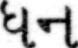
ધન
